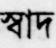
স্বাদ
